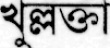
খুল্লক্তা
